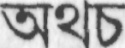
অথচ
